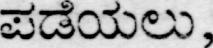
ಪಡೆಯಲು,
